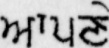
ਆਪਣੇ
